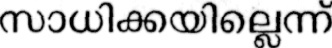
സാധിക്കയില്ലെന്ന്
